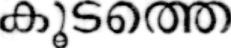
കൂടത്തെ
